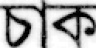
চাক
